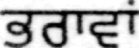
ਭਰਾਵਾਂ
